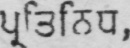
ਪ੍ਰਤਿਨਿਧ,
